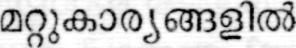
മറ്റുകാര്യങ്ങളില്‍
